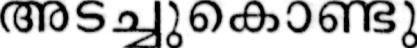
അടച്ചുകൊണ്ടു
